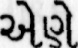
એણે
